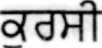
ਕੁਰਸੀ
